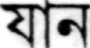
যান
